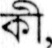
কী,
